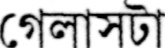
গেলাসটা
